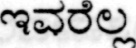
ಇವರೆಲ್ಲ
